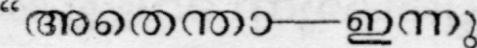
"അതെന്താ-ഇന്നു
